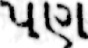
પણ
